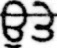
ਉਤੇ
